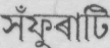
সঁফুৰাটি
